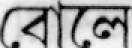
বোলে
